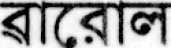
ৱারোল
